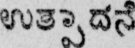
ಉತ್ಪಾದನೆ
